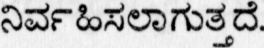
ನಿರ್ವಹಿಸಲಾಗುತ್ತದೆ.
